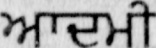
ਆਦਮੀ
